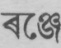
ৰঞ্জে
